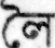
লৈ
